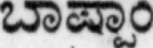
ಬಾಪ್ಪಾಂ
